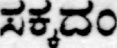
ಸಕ್ಕದಂ
